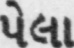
પેલા
